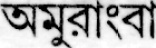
অমুরাংবা
